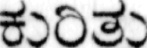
ಕುರಿತು
